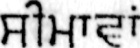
ਸੀਮਾਵਾਂ
